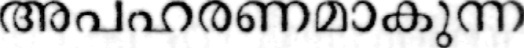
അപഹരണമാകുന്ന
